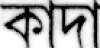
কাদা
